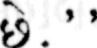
છે."
